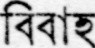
বিবাহ
